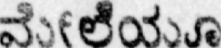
ಮೇಲೆಯೂ
